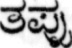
ತಪ್ಪು
